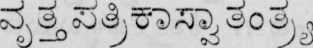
ವೃತ್ತಪತ್ರಿಕಾಸ್ವಾತಂತ್ರ್ಯ
